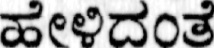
ಹೇಳಿದಂತೆ
